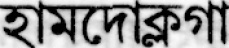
হামদোক্লগা
